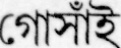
গোসাঁই
